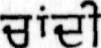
ਚਾਂਦੀ
